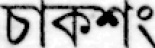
চাকশং
